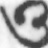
ও
